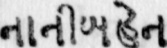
નાનીબહેન
